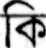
কি
